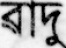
ৱাদু
